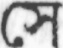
সে
